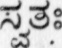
ಸ್ವತಃ
